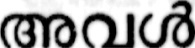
അവള്‍
